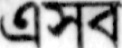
এসব
